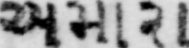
અમારા
